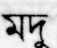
মদু
